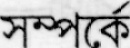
সম্পৰ্কে
